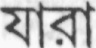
যারা
